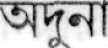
অদুনা
